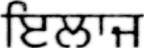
ਇਲਾਜ
